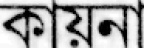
কায়না
